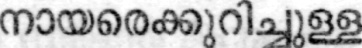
നായരെക്കുറിച്ചുള്ള
